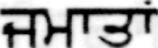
ਜਮਾਤਾਂ
